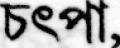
চৎপা,
